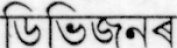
ডিভিজনৰ
